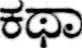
ಕಥಾ
